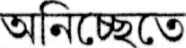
অনিচ্ছেতে
